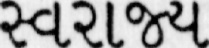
સ્વરાજ્ય
